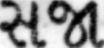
સજા
